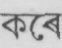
কৰে
